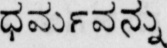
ಧರ್ಮವನ್ನು
